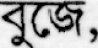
বুজে,
